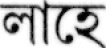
লাহে
